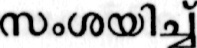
സംശയിച്ച്
